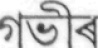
গভীৰ
